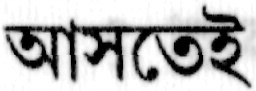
আসতেই
